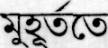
মুহূর্ততে
